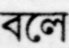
বলে
